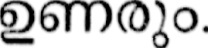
ഉണരും.
